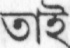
তাই
